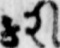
કરી
